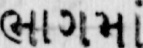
ભાગમાં
